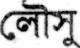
লৌসু
